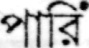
পারি
